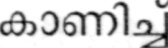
കാണിച്ച്
